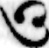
ও
